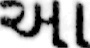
આ
